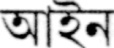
আইন
